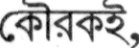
কৌরকই,
